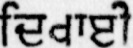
ਦਿਖਾਈ
